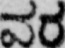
ವರ
